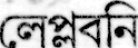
লেপ্লবনি
